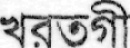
খরতগী
